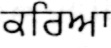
ਕਰਿਆ
